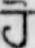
ਹੋ
